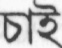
চাই
